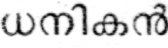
ധനികന്‍
